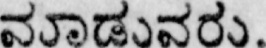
ಮಾಡುವರು.
